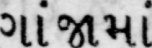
ગાંજામાં
